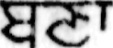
ਬਣਾ
